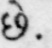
છે.
